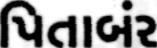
પિતાબંર
